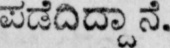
ಪಡೆದಿದ್ದಾನೆ.
